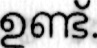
ഉണ്ട്.
